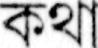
কথা
